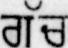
ਗੱਚ
